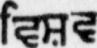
ਵਿਸ਼ਵ
